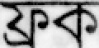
ফ্রক
